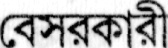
বেসরকারী
